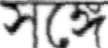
সঙ্গে
